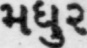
મધુર
